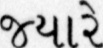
જ્યારે
